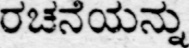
ರಚನೆಯನ್ನು
